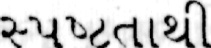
સ્પષ્ટતાથી
